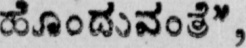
ಹೊಂದುವಂತೆ”,
